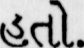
હતો.
